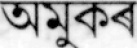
অমুকৰ
